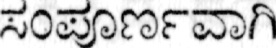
ಸಂಪೂರ್ಣವಾಗಿ
